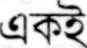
একই
